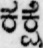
ಕಕ್ಷೆ
